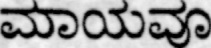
ಮಾಯವೂ
